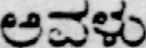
ಅವಳು
